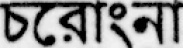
চরোংনা
